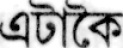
এটাকৈ
